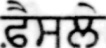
ਫ਼ੈਸਲੇ
